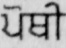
ਪੋਥੀ
